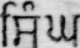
ਸਿੰਘ
